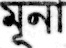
মূনা
